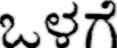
ಒಳಗೆ
